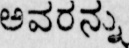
ಅವರನ್ನು
